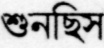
শুনছিস
